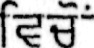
ਵਿਚੋਂ
